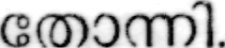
തോന്നി.
